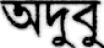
অদুবু
